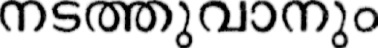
നടത്തുവാനും
